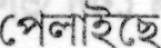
পেলাইছে
